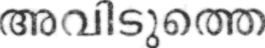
അവിടുത്തെ
